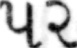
પર
